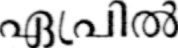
ഏപ്രില്‍
